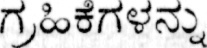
ಗ್ರಹಿಕೆಗಳನ್ನು
